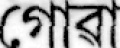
গোৱা
